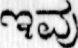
ಇವು
